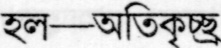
হল–অতিকৃচ্ছ্র
